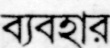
ব্যবহার
